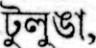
টুলুঙা,
